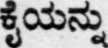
ಕೈಯನ್ನು
